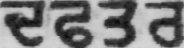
ਦਫਤਰ
